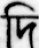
দি
